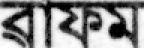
ৱাফম
